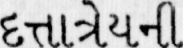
દત્તાત્રેયની
